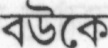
বউকে
